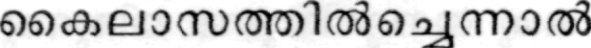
കൈലാസത്തില്‍ച്ചെന്നാല്‍
